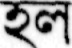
হল
